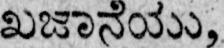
ಖಜಾನೆಯು,
